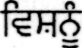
ਵਿਸ਼ਨੂੰ
